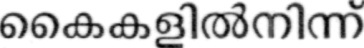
കൈകളില്‍നിന്ന്
